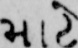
માટે
